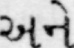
અને
